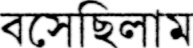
বসেছিলাম
